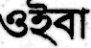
ওইবা
